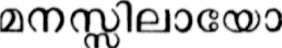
മനസ്സിലായോ
